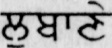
ਲੁਬਾਣੇ
